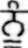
ਨੂੰ
